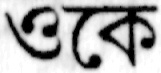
ওকে
